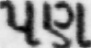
પણ
